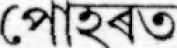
পোহৰত
